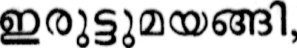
ഇരുട്ടുമയങ്ങി,
